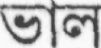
ভাল
